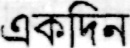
একদিন
